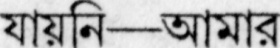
যায়নি-আমার
